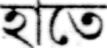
হাতে
